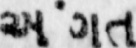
અંગત
